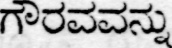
ಗೌರವವನ್ನು
